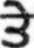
ਤੇ
